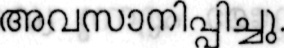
അവസാനിപ്പിച്ചു.
